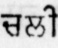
ਚਲੀ
